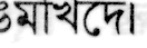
ঙমখিদে।
